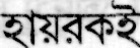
হায়রকই
